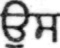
ਉਸ
